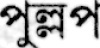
পুল্লপ
